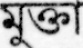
মুক্তা
